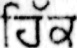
ਹਿੱਕ
